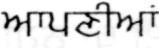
ਆਪਣੀਆਂ
